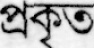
প্রকৃত
